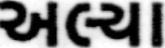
અવ્યા
